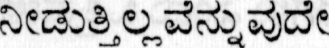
ನೀಡುತ್ತಿಲ್ಲವೆನ್ನುವುದೇ
